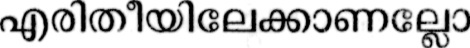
എരിതീയിലേക്കാണല്ലോ
